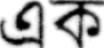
এক
